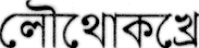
লৌথোকখ্রে
